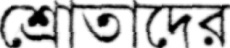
শ্রোতাদের
